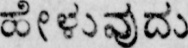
ಹೇಳುವುದು
